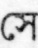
সে
